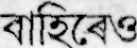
বাহিৰেও
